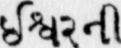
ઈશ્વરની
